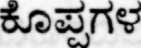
ಕೊಪ್ಪಗಳ
